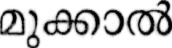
മുക്കാല്‍
